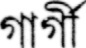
গার্গী
